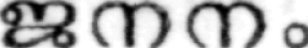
ജനനം
